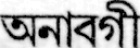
অনাবগী
